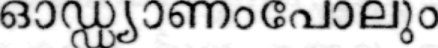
ഓഡ്ഡ്യാണംപോലും
